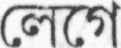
লেগে
